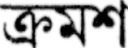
ক্রমশ
